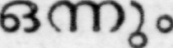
ഒന്നും
